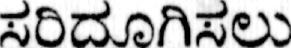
ಸರಿದೂಗಿಸಲು
